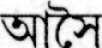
আসৈ
